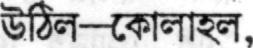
উঠিল—কোলাহল,
